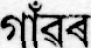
গাঁৱৰ
